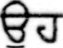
ਉਹ
